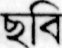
ছবি
